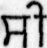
ਸੀ
